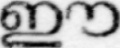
ഈ
